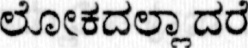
ಲೋಕದಲ್ಲಾದರೆ
